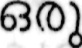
ഒരു
